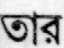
তার
